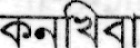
কনখিবা
